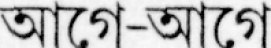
আগে-আগে
